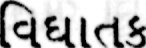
વિઘાતક
